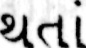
થતાં
